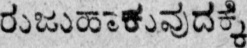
ರುಜುಹಾಕುವುದಕ್ಕೆ
